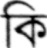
কি
